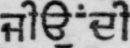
ਜੀਉਂਦੀ
